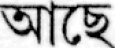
আছে
